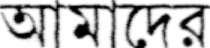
আমাদের
